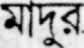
মাদুর
